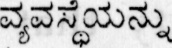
ವ್ಯವಸ್ಥೆಯನ್ನು
